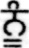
ਨੂੰ
